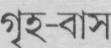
গৃহ-বাস
